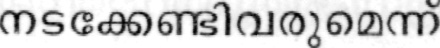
നടക്കേണ്ടിവരുമെന്ന്
